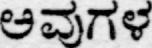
ಅವುಗಳ
